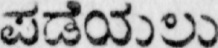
ಪಡೆಯಲು
